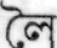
লৈ
